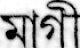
মাগী
